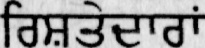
ਰਿਸ਼ਤੇਦਾਰਾਂ
